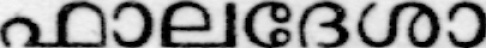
ഫാലദേശാ
